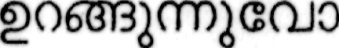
ഉറങ്ങുന്നുവോ
